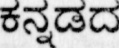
ಕನ್ನಡದ
